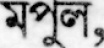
মপুল,
